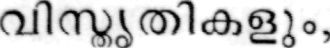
വിസ്തൃതികളും,
